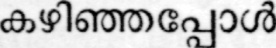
കഴിഞ്ഞപ്പോള്‍
